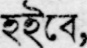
হইবে,
